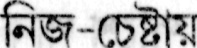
নিজ-চেষ্টায়
